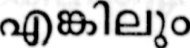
എങ്കിലും
